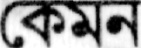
কেমন
